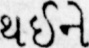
થઈને
